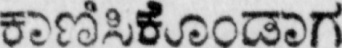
ಕಾಣಿಸಿಕೊಂಡಾಗ
